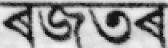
ৰজতৰ
